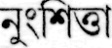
নুংশিত্তা
